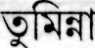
তুমিন্না
